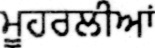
ਮੂਹਰਲੀਆਂ
